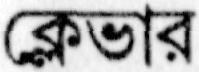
ক্লেভার
